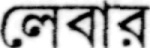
লেবার
